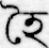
হৈ
